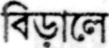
বিড়ালে
